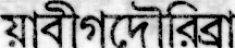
য়াবীগদৌরিব্রা
